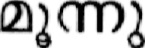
മൂന്നു
